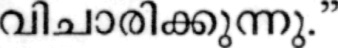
വിചാരിക്കുന്നു."
